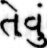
તેવું
